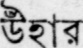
উঁহার
